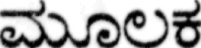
ಮೂಲಕ
